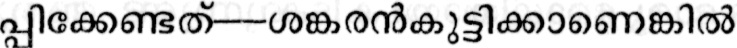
പ്പിക്കേണ്ടത്-ശങ്കരന്‍കുട്ടിക്കാണെങ്കില്‍
